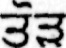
ਤੋੜ
